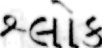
શ્લોક
